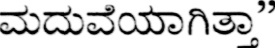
ಮದುವೆಯಾಗಿತ್ತಾ"
